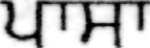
ਪਾਸਾ
